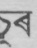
চূৰ
